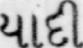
યાદી
